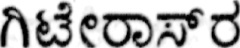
ಗಿಟೇರಾಸ್ರ
